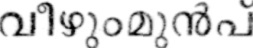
വീഴുംമുന്‍പ്
